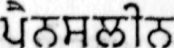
ਪੈਨਸਲੀਨ
